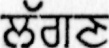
ਲੱਗਣ
